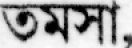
তমসা,
